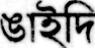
ঙাইদি
